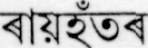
ৰায়হঁতৰ
